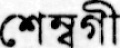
শেম্বগী
